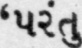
'પરંતુ
